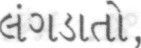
લંગડાતો,
